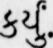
કર્યું.
